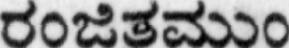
ರಂಜಿತಮುಂ
